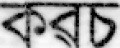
কৱচ
